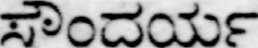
ಸೌಂದರ್ಯ
